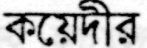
কয়েদীর
